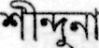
শীন্দুনা
